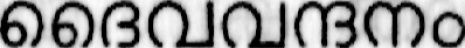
ദൈവവന്ദനം
